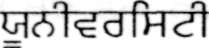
ਯੂਨੀਵਰਸਿਟੀ
